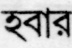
হবার
